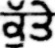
ਕੁੱਤੇ
